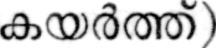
കയര്‍ത്ത്)
